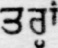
ਤਰ੍ਹਾਂ
